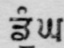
ਡੁੰਘ
